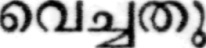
വെച്ചതു
